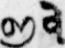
જીવે
